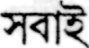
সবাই
